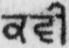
ਕਵੀ
